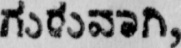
ಗುರುವಾಗಿ,
